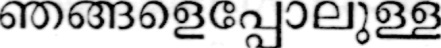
ഞങ്ങളെപ്പോലുള്ള
